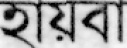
হায়বা
